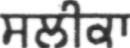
ਸਲੀਕਾ
